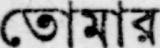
তোমার
